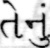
તેનું
